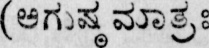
(ಅಗುಷ್ಠಮಾತ್ರಃ
